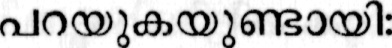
പറയുകയുണ്ടായി:
